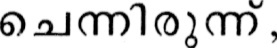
ചെന്നിരുന്ന്,
